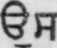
ਉਸ
